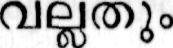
വല്ലതും
